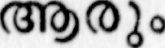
ആരും
